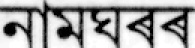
নামঘৰৰ
